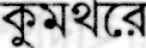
কুমথরে
